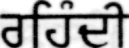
ਰਹਿੰਦੀ
